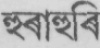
হুৰাহুৰি
